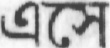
এসে
